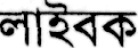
লাইবক
